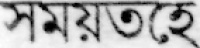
সময়তহে
